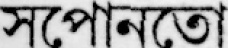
সপোনতো
